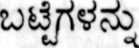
ಬಟ್ಟೆಗಳನ್ನು
